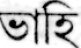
ভাহি
